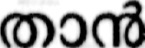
താന്‍
